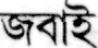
জবাই
